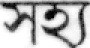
সহ্য
